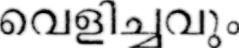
വെളിച്ചവും
